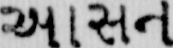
આસન
